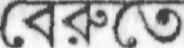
বেরুতে
